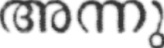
അന്നു
